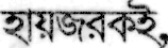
হায়জরকই,
